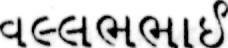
વલ્લભભાઈ
